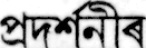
প্রদৰ্শনীৰ
